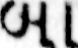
બા
